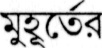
মুহূর্তের
